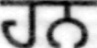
ਹਨ
